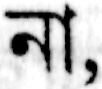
না,
